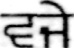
ਵਜੇ
